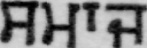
ਸਮਾਜ
